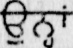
ਉਨ੍ਹਾਂ
